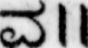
ವ||
